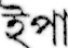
ইপা
